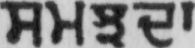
ਸਮਝਦਾ
